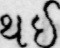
થઈ
